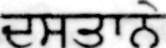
ਦਸਤਾਨੇ
